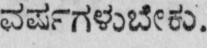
ವರ್ಷಗಳುಬೇಕು.
